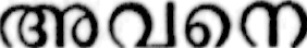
അവനെ
